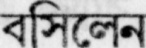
বসিলেন
